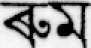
ৰুম
